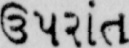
ઉપરાંત
